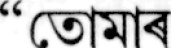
"তোমাৰ
